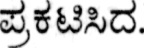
ಪ್ರಕಟಿಸಿದ.
